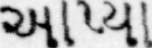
આપ્યા
